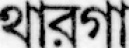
থারগা
